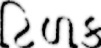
ટિળક
